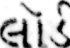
લૉર્ડ
